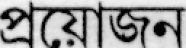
প্রয়োজন
